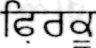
ਫ਼ਿਰਕੂ
